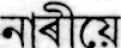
নাৰীয়ে
